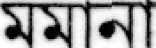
মমানা
